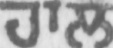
ਹਾਲ
